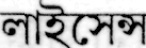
লাইসেন্স
